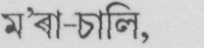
ম'ৰা-চালি,
